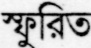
স্ফুরিত
